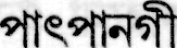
পাৎপানগী
